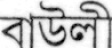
বাউলী
